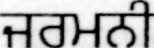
ਜਰਮਨੀ
